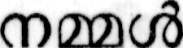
നമ്മള്‍
